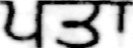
ਪਤਾ
